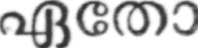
ഏതോ
